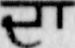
ਦਾ
